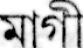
মাগী
